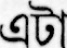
এটা
